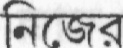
নিজের
